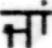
ਜਾਂ
